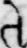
તે
